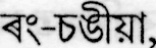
ৰং-চঙীয়া,
